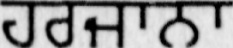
ਹਰਜਾਨਾ
